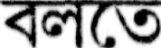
বলতে
